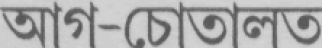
আগ-চোতালত
